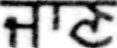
ਜਾਣ
